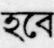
হবে
